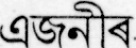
এজনীৰ
